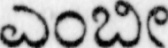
ಎಂಬೀ
